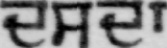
ਦਸਦਾ
